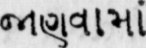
જાણવામાં
